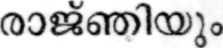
രാജ്ഞിയും
